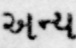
અન્ય
